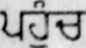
ਪਹੁੰਚ
